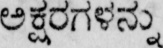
ಅಕ್ಷರಗಳನ್ನು
